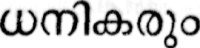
ധനികരും
